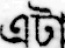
এটা
